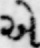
એ
